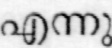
എന്നു
